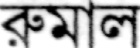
রুমাল
